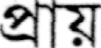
প্রায়
